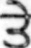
ਤੇ
